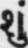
શું
